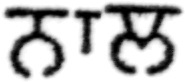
ਨਾਲ
